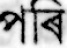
পৰি
